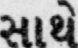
સાથે
